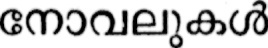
നോവലുകള്‍
